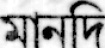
মানদি
